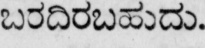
ಬರದಿರಬಹುದು.
